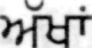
ਅੱਖਾਂ
